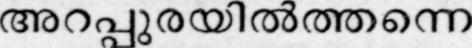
അറപ്പുരയില്‍ത്തന്നെ
